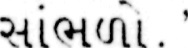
સાંભળો.'
